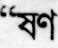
“ষণ
